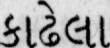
કાઢેલા
